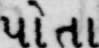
પોતા
